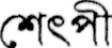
শেৎপী
